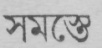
সমস্তে
